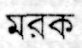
মরক
